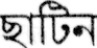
ছাটিন
